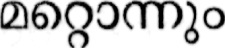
മറ്റൊന്നും
